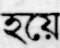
হয়ে
